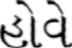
હોવે
